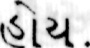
હોય.
